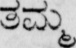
ತಮ್ಮ
